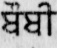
ਬੌਬੀ
